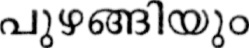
പുഴങ്ങിയും
